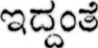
ಇದ್ದಂತೆ
